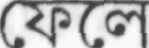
ফেলে
